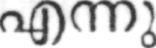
എന്നു
